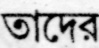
তাদের
